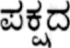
ಪಕ್ಷದ
